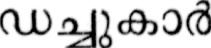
ഡച്ചുകാര്‍
